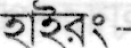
হাইরং-
